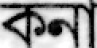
কনা
